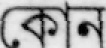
কোন
